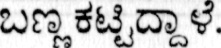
ಬಣ್ಣಕಟ್ಟಿದ್ದಾಳೆ.
